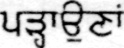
ਪੜ੍ਹਾਉਣਾਂ
